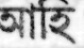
আহি
